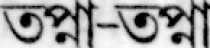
তপ্না-তপ্না
